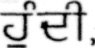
ਹੁੰਦੀ,
